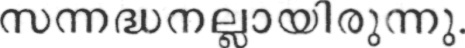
സന്നദ്ധനല്ലായിരുന്നു.
